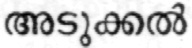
അടുക്കല്‍
